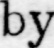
by
